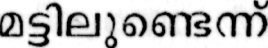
മട്ടിലുണ്ടെന്ന്
